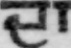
ਦਾ
